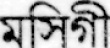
মসিগী
